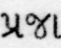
પ્રજા
